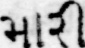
મારી
